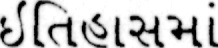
ઈતિહાસમાં
